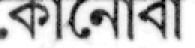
কোনোবা
